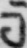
ਹੋ
